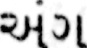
અંગ
